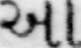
આ
